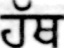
ਹੱਥ
